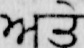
ਅਤੇ
